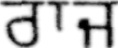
ਰਾਜ
